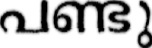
പണ്ടു
